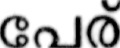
പേര്
